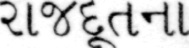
રાજદૂતના
